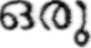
ഒരു
